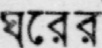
ঘরের
